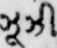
ઝૂઝી
